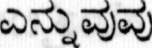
ಎನ್ನುವುವು
